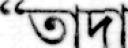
“তাদা
